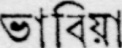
ভাবিয়া
